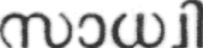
സാധ്വി
